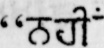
''ਨਹੀਂ
